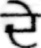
ਦੇ
